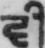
ਵੀ
